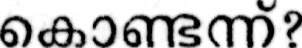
കൊണ്ടന്ന്?
